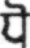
ਧੋ
